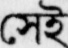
সেই
